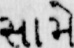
સામે
